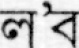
ল'ব
